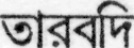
তারবদি
